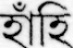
হাঁহি
